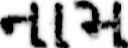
નામ
